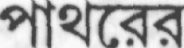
পাথরের
